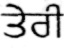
ਤੇਰੀ
